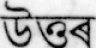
উত্তৰ
